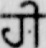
ਹੀ
